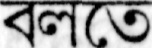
বলতে
